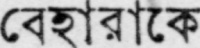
বেহারাকে
